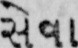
સેવા
